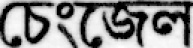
চেংজেল
